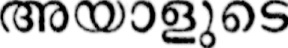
അയാളുടെ
